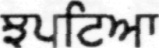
ਝਪਟਿਆ
